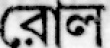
রোল
